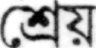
শ্রেয়
